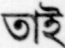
তাই
